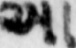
આ
